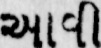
આવી
